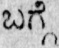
ಬಗ್ಗೆ
